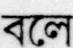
বলে
